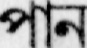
পান
